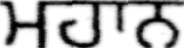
ਮਹਾਨ
